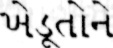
ખેડૂતોને
